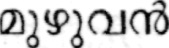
മുഴുവന്‍
